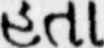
હતા
